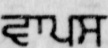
ਵਾਪਸ
